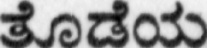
ತೊಡೆಯ
